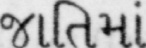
જાતિમાં
